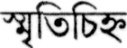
স্মৃতিচিহ্ন
